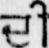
ਦੀ
